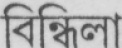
বিন্ধিলা
